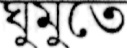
ঘুমুতে
